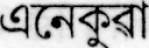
এনেকুৱা
